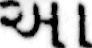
આ
